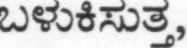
ಬಳುಕಿಸುತ್ತ,
